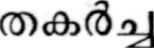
തകര്‍ച്ച
